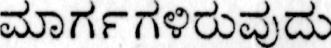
ಮಾರ್ಗಗಳಿರುವುದು
